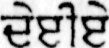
ਦੇਈਏ
